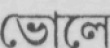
ভোলে
